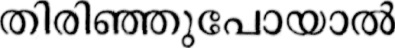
തിരിഞ്ഞുപോയാല്‍
